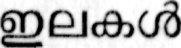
ഇലകള്‍
